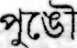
পুঙৌ
